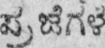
ಪ್ರಜೆಗಳ
